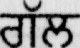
ਗੱਲ
